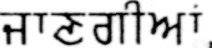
ਜਾਣਗੀਆਂ,
